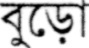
বুড়ো
